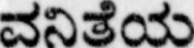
ವನಿತೆಯ
